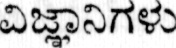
ವಿಜ್ಞಾನಿಗಳು
